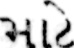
માટે
